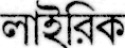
লাইরিক
